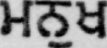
ਮਨੁਖ
